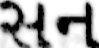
સન
